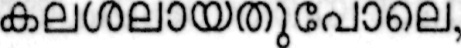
കലശലായതുപോലെ,
